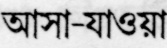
আসা-যাওয়া
